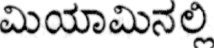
ಮಿಯಾಮಿನಲ್ಲಿ
